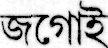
জগোই
